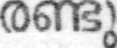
രണ്ടു
